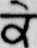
ਕੇ
